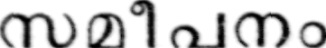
സമീപനം
